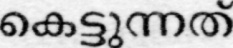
കെട്ടുന്നത്
